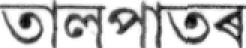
তালপাতৰ
